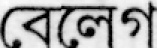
বেলেগ
